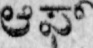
ಆಫ್
